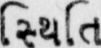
સ્થિતિ
